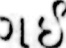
ગઈ
